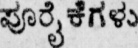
ಪೂರೈಕೆಗಳು
